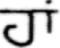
ਹਾਂ
